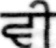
ਵੀ
